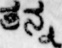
ತನ್ನ
